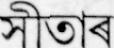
সীতাৰ
